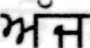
ਅੱਜ
